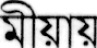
মীয়ায়
